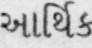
આર્થિક
